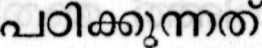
പഠിക്കുന്നത്
